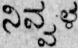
ನಿವ್ವಳ
